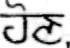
ਹੋਣ,
